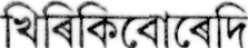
খিৰিকিবোৰেদি
